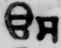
ਉਸ
